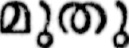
മുതു
